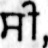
ਸੀ,
